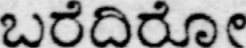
ಬರೆದಿರೋ
